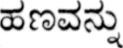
ಹಣವನ್ನು
